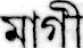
মাগী
